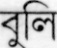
বুলি
